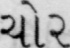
ચોર
